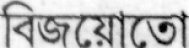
বিজয়োতো
